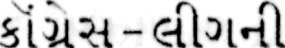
કૉંગ્રેસ-લીગની
